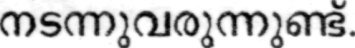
നടന്നുവരുന്നുണ്ട്.
